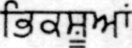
ਭਿਕਸ਼ੂਆਂ
